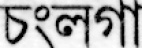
চংলগা
